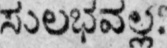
ಸುಲಭವಲ್ಲ
